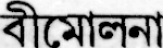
বীমোলনা
